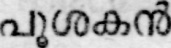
പൂശകന്‍
